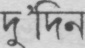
দুদিন
